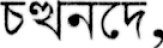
চত্থনদে,
